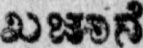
ಖಜಾನೆ
